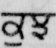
ਕੁਝ
